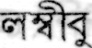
লম্বীবু
